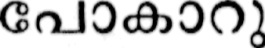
പോകാറു
